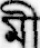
মী
